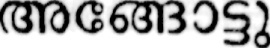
അങ്ങോട്ടു
